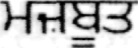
ਮਜ਼ਬੂਤ
